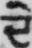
ਦੇ
